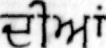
ਦੀਆਂ
